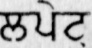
ਲਪੇਟ
